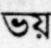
ভয়
